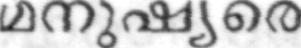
മനുഷ്യരെ
